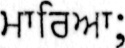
ਮਾਰਿਆ;
